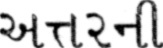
અત્તરની
